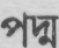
পদ্ম
